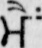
ਮੈਂ
